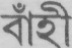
বাঁহী
